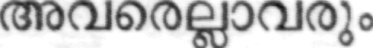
അവരെല്ലാവരും
